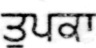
ਤੁਪਕਾ
